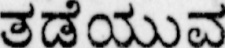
ತಡೆಯುವ
